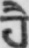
ਹੈ
